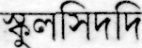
স্কুলসিদদি
